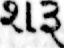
શરૂ
